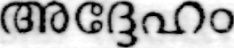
അദ്ദേഹം
